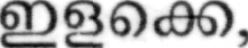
ഇളക്കെ,
